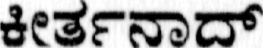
ಕೀರ್ತನಾದ್
